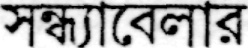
সন্ধ্যাবেলার
